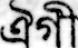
ঐগী
